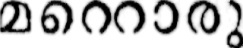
മറെറാരു
